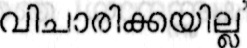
വിചാരിക്കയില്ല'
